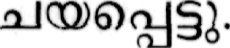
ചയപ്പെട്ടു.
